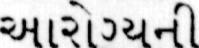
આરોગ્યની
